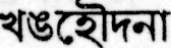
খঙহৌদনা
